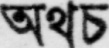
অথচ
